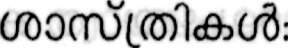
ശാസ്ത്രികള്‍:
